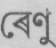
ৰেণু
